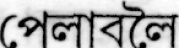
পেলাবলৈ
